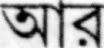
আর
